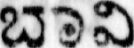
ಬಾವಿ
